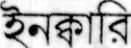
ইনক্বারি
